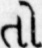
તો
